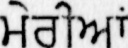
ਮੇਰੀਆਂ
